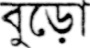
বুড়ো
